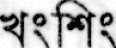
খংশিং
